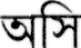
অসি
